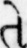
તે
